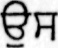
ਉਸ
